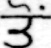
ਤੋਂ
